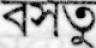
বসতু
